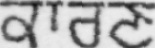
ਕਾਰਣ
